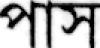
পাস
